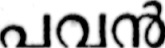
പവന്‍
